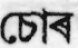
চোৰ
